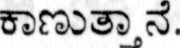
ಕಾಣುತ್ತಾನೆ.
